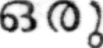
ഒരു
